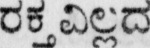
ರಕ್ತವಿಲ್ಲದ
